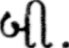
બી.
